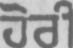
ਹੋਰੀ
